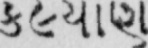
કલ્યાણ
